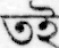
তই
